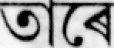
তাৰে
